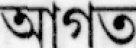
আগত
